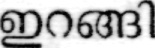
ഇറങ്ങി
